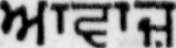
ਆਵਾਜ਼
